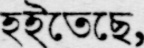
হইতেছে,
